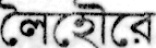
লৈহৌরে
